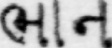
ભાન
